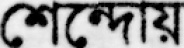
শেন্দোয়
